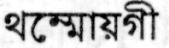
থম্মোয়গী
